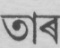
তাৰ
